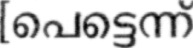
[പെട്ടെന്ന്
